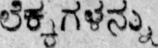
ಲೆಕ್ಕಗಳನ್ನು
